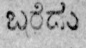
ಬರೆದು
